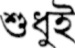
শুধুই
